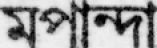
মপান্দা
